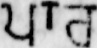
ਪਾਰ
